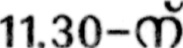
11.30-ന്
